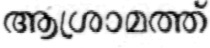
ആശ്രാമത്ത്
